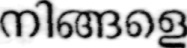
നിങ്ങളെ
